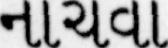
નાચવા
